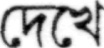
দেখে
